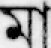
মা
